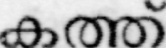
കത്ത്
